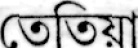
তেতিয়া
